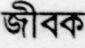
জীবক
